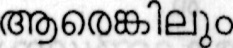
ആരെങ്കിലും
